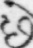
છે
